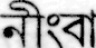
নীংবা
